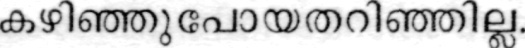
കഴിഞ്ഞുപോയതറിഞ്ഞില്ല.
